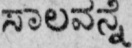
ಸಾಲವನ್ನೆ
